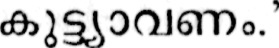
കുട്ട്യാവണം.’
